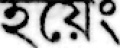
হয়েং
